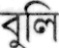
বুলি
